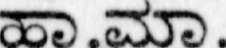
ಹಾ.ಮಾ.
